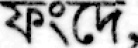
ফংদে,
